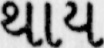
થાય
